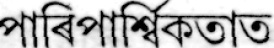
পাৰিপাৰ্শ্বিকতাত
